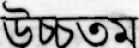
উচ্চতম
